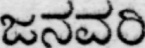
ಜನವರಿ
